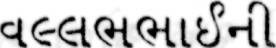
વલ્લભભાઈની
